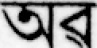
অৱ
